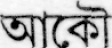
আকৌ
